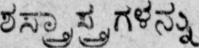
ಶಸ್ತ್ರಾಸ್ತ್ರಗಳನ್ನು
